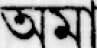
অমা
